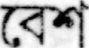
বেশ
